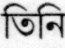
তিনি
